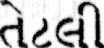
તેટલી
